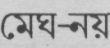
মেঘ-নয়
